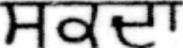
ਸਕਦਾ
